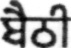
ਬੈਠੀ
